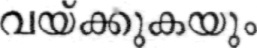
വയ്ക്കുകയും
